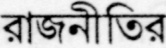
রাজনীতির
